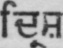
ਦ੍ਰਿਸ਼
